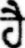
ਹੈ
